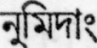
নুমিদাং
